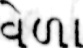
વેળા
